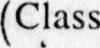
(Class
